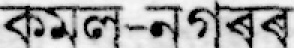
কমল-নগৰৰ
